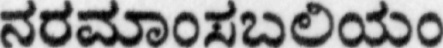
ನರಮಾಂಸಬಲಿಯಂ
